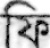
ফি
